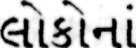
લોકોનાં
